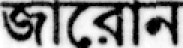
জারোন
